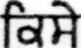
ਕਿਸੇ
